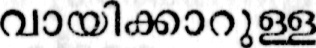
വായിക്കാറുള്ള
